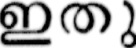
ഇതു
